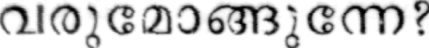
വരുമോങ്ങുന്നേ?
